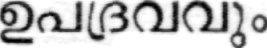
ഉപദ്രവവും
